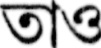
তাও
